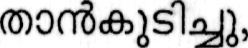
താന്‍കുടിച്ചു,
